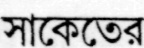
সাকেতের
